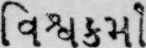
વિશ્વકર્મા
